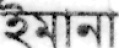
ইমানা
